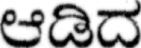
ಆಡಿದ
